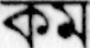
কম
